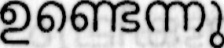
ഉണ്ടെന്നു
